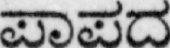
ಪಾಪದ
